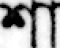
শা
